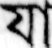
যা
